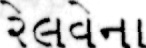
રેલવેના
